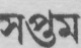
সপ্তম
